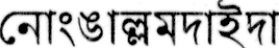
নোংঙাল্লমদাইদা
